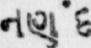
નણંદ
